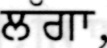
ਲੱਗਾ,
